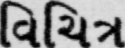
વિચિત્ર
